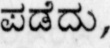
ಪಡೆದು,
